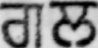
ਗਲ
